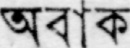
অবাক
